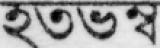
হতভম্ব
